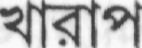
খারাপ
